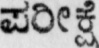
ಪರೀಕ್ಷೆ
